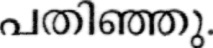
പതിഞ്ഞു.
